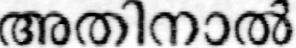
അതിനാല്‍
